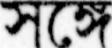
সঙ্গে
